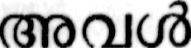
അവള്‍
